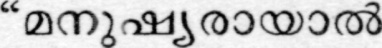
"മനുഷ്യരായാല്‍
